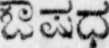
ಔಷಧ
